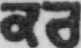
ਕਰ
